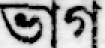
ভাগ
